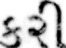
કરી
